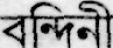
বন্দিনী
